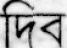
দিব
